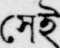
সেই
